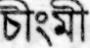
চীংমী
